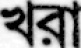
খরা
